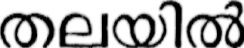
തലയില്‍
